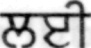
ਲਈ
